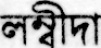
লম্বীদা
